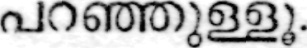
പറഞ്ഞുള്ളൂ.
